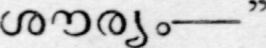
ശൌര്യം-”
